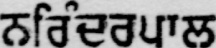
ਨਰਿੰਦਰਪਾਲ
